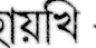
হায়খি
